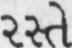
રસ્તે
